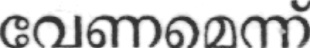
വേണമെന്ന്
